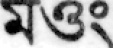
মওং
